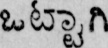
ಒಟ್ಟಾಗಿ
